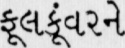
ફૂલકૂવરને
